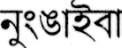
নুংঙাইবা
